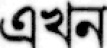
এখন
